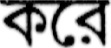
করে
